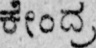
ಕೇಂದ್ರ
